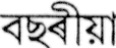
বছৰীয়া
